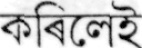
কৰিলেই
